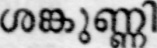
ശങ്കുണ്ണി.
